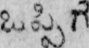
ಒಪ್ಪಿಗೆ
